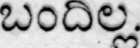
ಬಂದಿಲ್ಲ.
